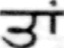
ਤਾਂ
